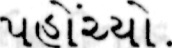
પહોંચ્યો.
